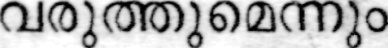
വരുത്തുമെന്നും
